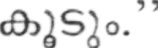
കൂടും."
